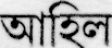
আহিল
